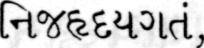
નિજહદગતં,
